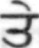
ਤੇ
